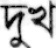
দুখ
